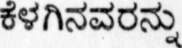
ಕೆಳಗಿನವರನ್ನು
